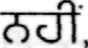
ਨਹੀਂ,
